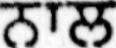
ਨਾਲ
